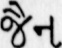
જૈન
